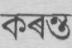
কৰন্ত
